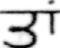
ਤਾਂ
